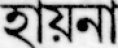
হায়না
